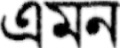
এমন
